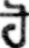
ਹੋ
